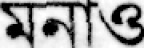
মনাও
